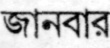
জানবার
